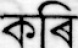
কৰি
